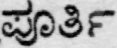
ಪೂರ್ತಿ
